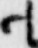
ન
